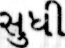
સુધી
